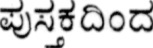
ಪುಸ್ತಕದಿಂದ
